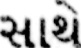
સાથે
